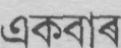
একবাৰ
